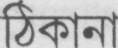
ঠিকানা
